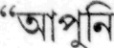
"আপুনি
